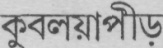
কুবলয়াপীড়
